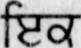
ਇਕ
